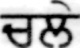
ਚਲੇ
